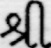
શ્રી
